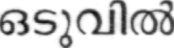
ഒടുവില്‍
